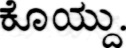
ಕೊಯ್ದು.
